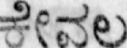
ಕೇವಲ
